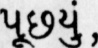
પૂછયું,
